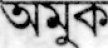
অমুক
